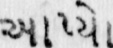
આપ્યો
